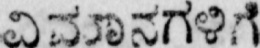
ವಿಮಾನಗಳಿಗೆ
